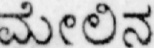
ಮೇಲಿನ
